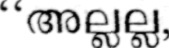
"അല്ലല്ല,
